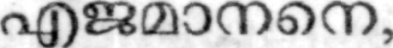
എജമാനനെ,
